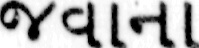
જવાના
